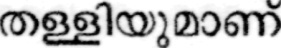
തള്ളിയുമാണ്
